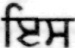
ਇਸ
